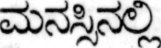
ಮನಸ್ಸಿನಲ್ಲಿ
